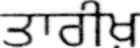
ਤਾਰੀਖ਼
